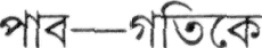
পাব-গতিকে
